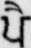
ਪੈ
